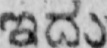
ಇದು
